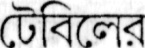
টেবিলের
